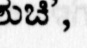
‘ಶುಚಿ’,
